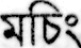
মচিং
